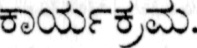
ಕಾರ್ಯಕ್ರಮ.
